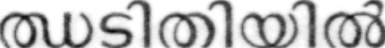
ഝടിതിയില്‍
